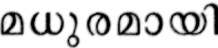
മധുരമായി
